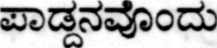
ಪಾಡ್ದನವೊಂದು
